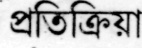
প্রতিক্রিয়া
